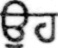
ਉਹ
